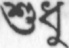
শুধু
